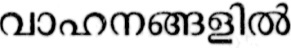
വാഹനങ്ങളില്‍
